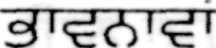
ਭਾਵਨਾਵਾਂ
